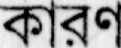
কারণ
